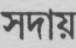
সদায়
